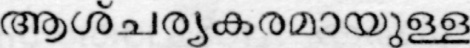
ആശ്ചര്യകരമായുള്ള
